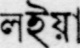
লইয়া
